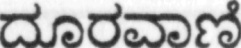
ದೂರವಾಣಿ
